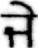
ਜੇ
